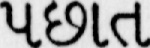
પછાત
